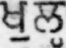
ਖੁਲ੍ਹ
